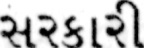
સરકારી
